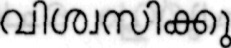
വിശ്വസിക്കു
